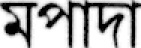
মপাদা
